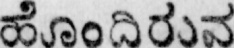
ಹೊಂದಿರುವ
